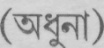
(অধুনা)
